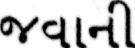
જવાની
